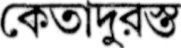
কেতাদুরস্ত
